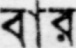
বার
